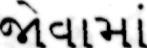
જોવામાં
